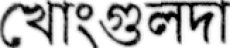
খোংগুলদা
